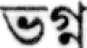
ভগ্ন
